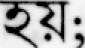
হয়;
